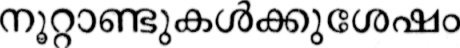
നൂറ്റാണ്ടുകള്‍ക്കുശേഷം
